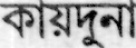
কায়দুনা
